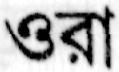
ওরা
